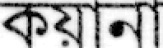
কয়ানা
